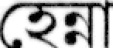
হেন্না
